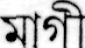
মাগী
